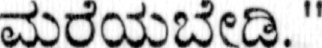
ಮರೆಯಬೇಡಿ.”
